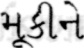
મૂકીને
